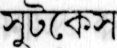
সুটকেস
